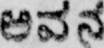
ಅವನ
